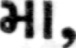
મા,
